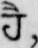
ਹੈ,
